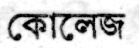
কোলেজ
